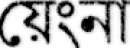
য়েংনা
